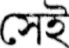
সেই
